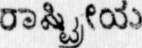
ರಾಷ್ಟ್ರೀಯ
